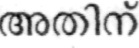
അതിന്
